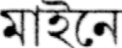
মাইনে
